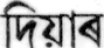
দিয়াৰ
